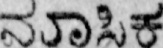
ಮಾಸಿಕ
